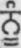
ਨੂੰ
